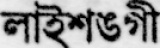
লাইশঙগী
